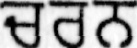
ਚਰਨ
